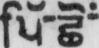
ਪਿੱਛੋਂ
